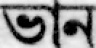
ভান
